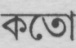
কতো
